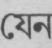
যেন
